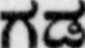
ಗಡ
